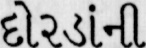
દોરડાંની
